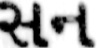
સન
